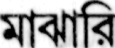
মাঝারি
